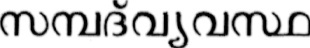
സമ്പദ്വ്യവസ്ഥ
